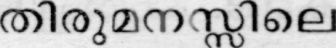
തിരുമനസ്സിലെ
